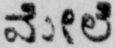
ಮೇಲೆ
